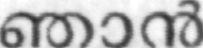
ഞാന്‍
